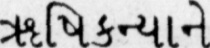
ૠષિકન્યાને
